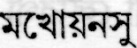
মখোয়নসু
